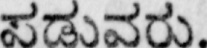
ಪಡುವರು.
